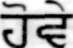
ਹੋਵੇ
